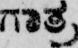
ಗಾತ್ರ
